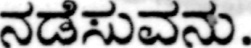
ನಡೆಸುವನು.
